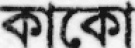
কাকো
